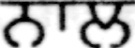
ਨਾਲ
